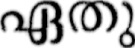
ഏതു
